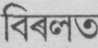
বিৰলত
